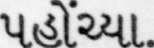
પહોંચ્યા.
